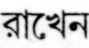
রাখেন
